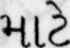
માટે
